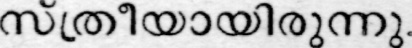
സ്ത്രീയായിരുന്നു.
